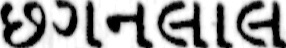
છગનલાલ
